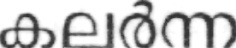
കലര്‍ന്ന
